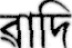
ৱাদি
